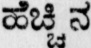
ಹೆಚ್ಚಿನ
